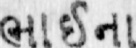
ભાઈના
